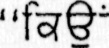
''ਕਿਉਂ
